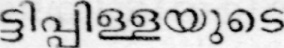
ട്ടിപ്പിള്ളയുടെ
